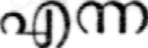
എന്ന
